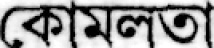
কোমলতা
